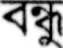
বন্ধু
